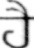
ਹੈ
